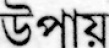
উপায়
